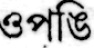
ওপঙি
